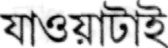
যাওয়াটাই
